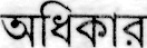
অধিকার
